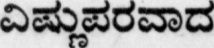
ವಿಷ್ಣುಪರವಾದ
